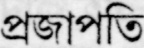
প্রজাপতি
